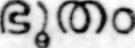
ഭൂതം
